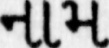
નામ
